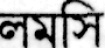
লমসি
